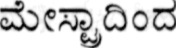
ಮೇಸ್ಟ್ರಾದಿಂದ
